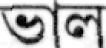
ভাল
